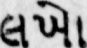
લખો
